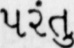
પરંતુ
